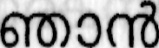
ഞാന്‍
